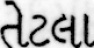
તેટલા
